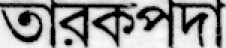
তারকপদা
